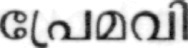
പ്രേമവി
